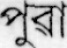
পুৱা
